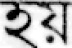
হয়
